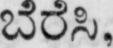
ಬೆರೆಸಿ,
